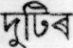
দুটিৰ
